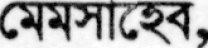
মেমসাহেব,
